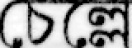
চেল্লে
